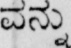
ವನ್ನು
